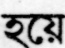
হয়ে
